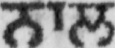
ਨਾਲ
